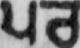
ਪਰ
